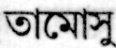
তামোসু
